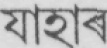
যাহাৰ
